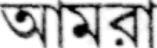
আমরা
